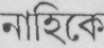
নাহিকে
